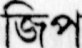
জিপ
